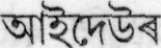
আইদেউৰ
